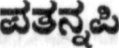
ಪತನ್ನಪಿ
